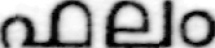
ഫലം
